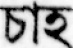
চাহ
